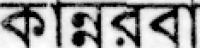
কান্নরবা
